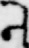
ને
